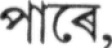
পাৰে,
